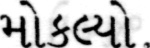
મોકલ્યો.
